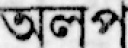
অলপ
